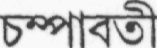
চম্পাবতী
